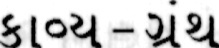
કાવ્ય-ગ્રંથ
